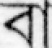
বা
